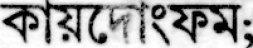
কায়দোংফম;
